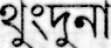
থুংদুনা
